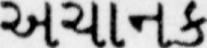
અચાનક
